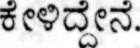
ಕೇಳಿದ್ದೇನೆ.
